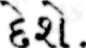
દેશે.
